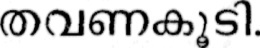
തവണകൂടി.
